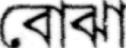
বোঝা
